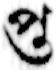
প্ত
